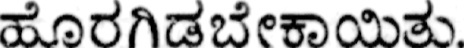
ಹೊರಗಿಡಬೇಕಾಯಿತು.
